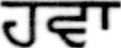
ਹਵਾ
